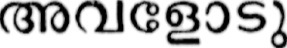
അവളോടു
